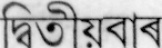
দ্বিতীয়বাৰ
